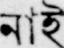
নাই
